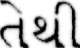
તેથી
